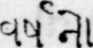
વર્ષનો
